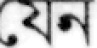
যেন
